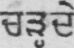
ਚੜ੍ਹਦੇ
